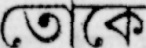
তোকে
